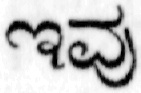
ಇವು
